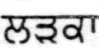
ਲੜਕਾ
